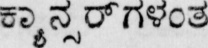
ಕ್ಯಾನ್ಸರ್‌ಗಳ೦ತ
